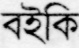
বইকি
